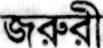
জরুরী
